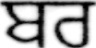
ਬਰ
